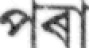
পৰা
